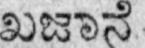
ಖಜಾನೆ
